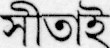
সীতাই
